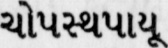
ચોપસ્થપાયૂ
